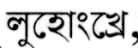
লুহোংখ্রে,
